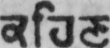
ਕਹਿਣ
